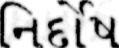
નિર્દોષ
